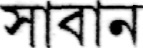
সাবান
